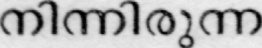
നിന്നിരുന്ന
